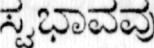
ಸ್ವಭಾವವು
